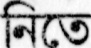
নিতে
